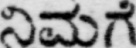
ನಿಮಗೆ
